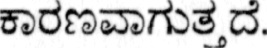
ಕಾರಣವಾಗುತ್ತದೆ.
